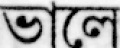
ভালে
